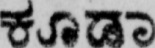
ಕೂಡಾ
